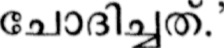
ചോദിച്ചത്.’
